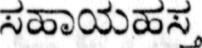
ಸಹಾಯಹಸ್ತ
